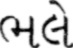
ભલે
